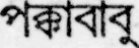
পক্কাবাবু
